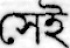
সেই
